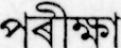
পৰীক্ষা
